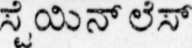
ಸ್ಟೆಯಿನ್ ಲೆಸ್
